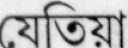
যেতিয়া
